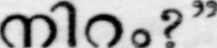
നിറം?"
